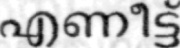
എണീട്ട്
